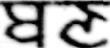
ਬਣ
